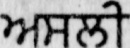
ਅਸਲੀ
